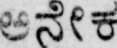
ಅನೇಕ
